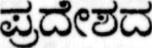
ಪ್ರದೇಶದ
